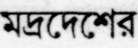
মদ্রদেশের
